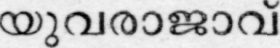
യുവരാജാവ്
